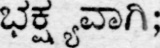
ಭಕ್ಷ್ಯವಾಗಿ;
